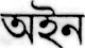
অইন
